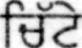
ਚਿੱਟੇ
